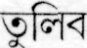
তুলিব
